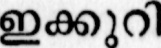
ഇക്കുറി
